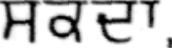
ਸਕਦਾ,
